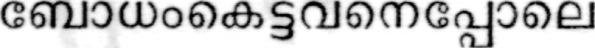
ബോധംകെട്ടവനെപ്പോലെ
